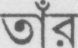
তাঁর
